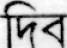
দিব
